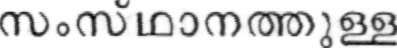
സംസ്ഥാനത്തുള്ള
